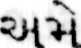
અમે
